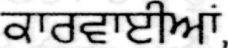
ਕਾਰਵਾਈਆਂ,
